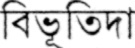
বিভূতিদা
